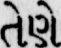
તેણે
